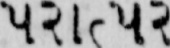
પરાત્પર
